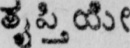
ತೃಪ್ತಿಯೇ
